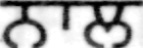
ਨਾਲ
